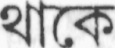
থাকে
